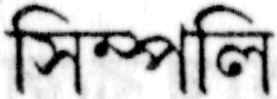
সিম্পলি
